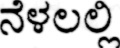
ನೆಳಲಲ್ಲಿ
